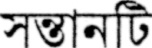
সন্তানটি
